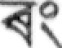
ৰং
